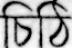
চিঠি
